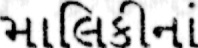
માલિકીનાં
